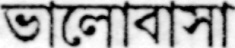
ভালোবাসা
